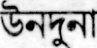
উনদুনা
